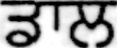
ਡਾਲ
